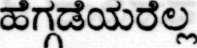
ಹೆಗ್ಗಡೆಯರೆಲ್ಲ
